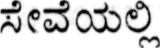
ಸೇವೆಯಲ್ಲಿ
